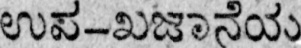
ಉಪ-ಖಜಾನೆಯ
